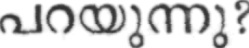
പറയുന്നു?
